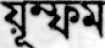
য়ূম্ফম
